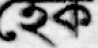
হেক
